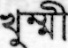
খুম্মি
